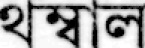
থম্বাল
